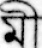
মী
